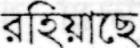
রহিয়াছে
